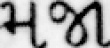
મજા
